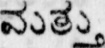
ಮತ್ತು
